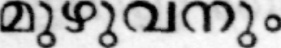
മുഴുവനും
